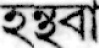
হন্থবা
